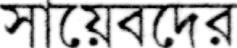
সায়েবদের
